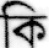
কি
